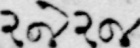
રજેરજ
